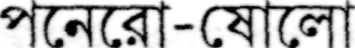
পনেরো-ষোলো
